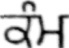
ਕੰਮ
